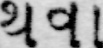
થવા
